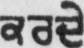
ਕਰਦੇ
